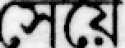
সেয়ে
